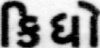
કિધો
